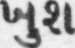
ખુશ
